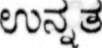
ಉನ್ನತ
